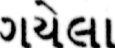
ગયેલા
